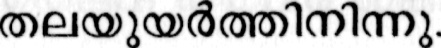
തലയുയര്‍ത്തിനിന്നു.
